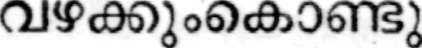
വഴക്കുംകൊണ്ടു
